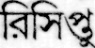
রিসিপ্তু
